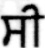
ਸੀ
